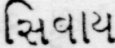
સિવાય
